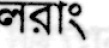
লৈরাং
